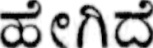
ಹೇಗಿದೆ
